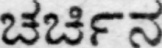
ಚರ್ಚಿನ
